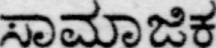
ಸಾಮಾಜಿಕ
